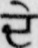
ਦੇ
